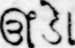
ઊંડો
